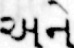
અને
